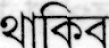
থাকিব
